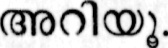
അറിയൂ.
